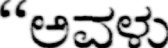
"ಅವಳು
